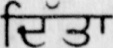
ਦਿੱਤਾ
